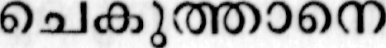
ചെകുത്താനെ
